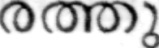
രത്തു
